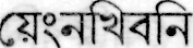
য়েংনখিবনি
